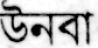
উনবা
